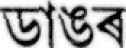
ডাঙৰ
